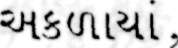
અકળાયાં,
